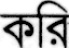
করি
